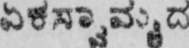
ಏಕಸ್ವಾಮ್ಯದ
